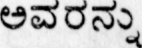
ಅವರನ್ನು
